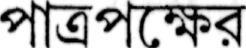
পাত্রপক্ষের
